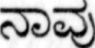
ನಾವು
